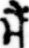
ਮੈਂ
